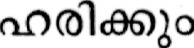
ഹരിക്കും
